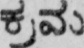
ಕ್ರಮ
